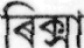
ৰিক্সা
